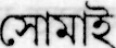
সোমাই
